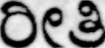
ರೀತಿ
